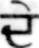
ਦੇ
